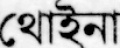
থোইনা
